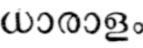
ധാരാളം
